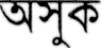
অসুক
